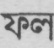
ফল
